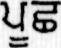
ਪੂਛ
